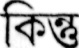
কিন্তু
